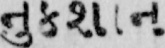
નુકશાન
